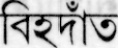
বিহদাঁত
